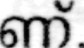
ണ്.
